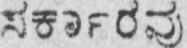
ಸರ್ಕಾರವು
